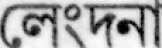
লেংদনা
